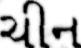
ચીન
